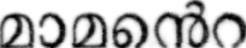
മാമന്റെ
